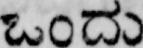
ಒಂದು
